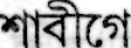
শাবীগে
